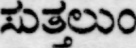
ಸುತ್ತಲುಂ
